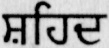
ਸ਼ਹਿਦ
